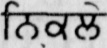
ਨਿਕਲੇ
